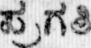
ಪ್ರಗತಿ
